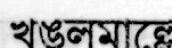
থোঙজীন্দা
